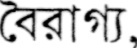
বৈরাগ্য,
